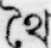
থৈ
